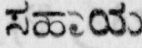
ಸಹಾಯ
